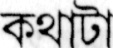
কথাটা
